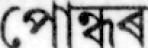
পোন্ধৰ
